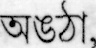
অঙঠা,
